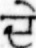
ਦੇ
